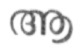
ആ
